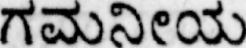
ಗಮನೀಯ
